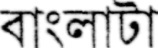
বাংলাটা
